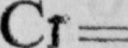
Cr=
